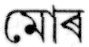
মোৰ
